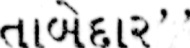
તાબેદાર"
